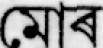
মোৰ
